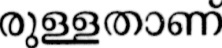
രുള്ളതാണ്
